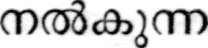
നല്‍കുന്ന
